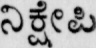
ನಿಕ್ಷೇಪಿ
